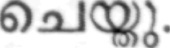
ചെയ്തു.
